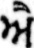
ਐ
